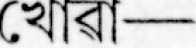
খোৱা-
